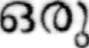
ഒരു
